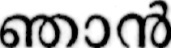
ഞാന്‍
